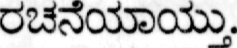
ರಚನೆಯಾಯ್ತು.
